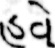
હવે
